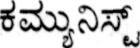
ಕಮ್ಯುನಿಸ್ಟ್
